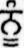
ਨੂੰ
